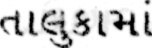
તાલુકામાં
